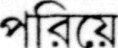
পরিয়ে
